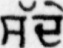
ਸੱਦੇ
